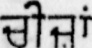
ਚੀਜ਼ਾਂ
